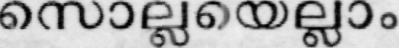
സൊല്ലയെല്ലാം
